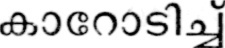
കാറോടിച്ച്
